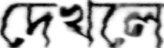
দেখলে
